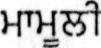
ਮਾਮੂਲੀ
